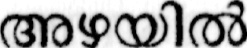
അഴയില്‍
